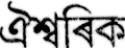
ঐশ্বৰিক
